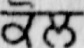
ਕੋਲ
